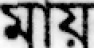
মায়
